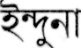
ইন্দুনা
